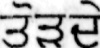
ਤੋੜਦੇ
